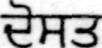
ਦੋਸਤ
